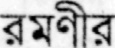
রমণীর
